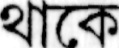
থাকে
